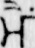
ਮੈਂ
